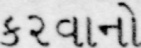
કરવાનો
